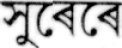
সুৰেৰে
